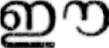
ഈ
